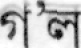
গ'ল
